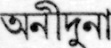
অনীদুনা
